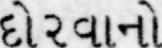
દોરવાનો
